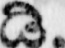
ಡಿ.
